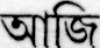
আজি
